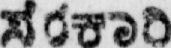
ಸರಕಾರಿ
